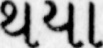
થયા
